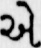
એ
